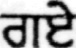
ਗਏ
